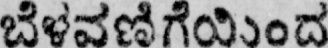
ಬೆಳವಣಿಗೆಯಿಂದ
